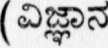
(ವಿಜ್ಞಾನ
